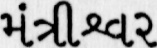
મંત્રીશ્વર
